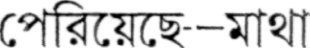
পেরিয়েছে–মাথা
